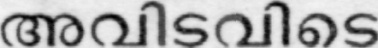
അവിടവിടെ
